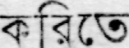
করিতে
